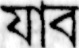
যাব
